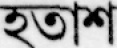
হতাশ
